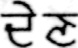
ਦੇਣ
